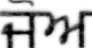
ਜੋਅ
